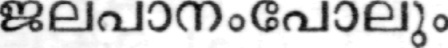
ജലപാനംപോലും
